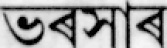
ভৰসাৰ
